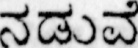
ನಡುವೆ
